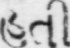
હતી
